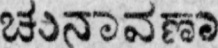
ಚುನಾವಣಾ
